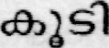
കൂടി
